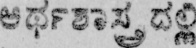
ಅರ್ಥಶಾಸ್ತ್ರದಲ್ಲಿ
